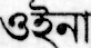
ওইনা
